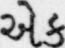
એક
